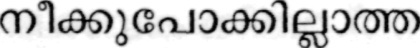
നീക്കുപോക്കില്ലാത്ത
